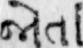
જોતાં
